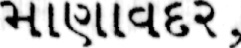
માણાવદર,
